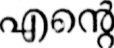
എന്റെ
